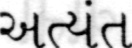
અત્યંત
